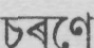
চৰণে
